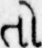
તો
